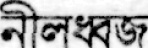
নীলধ্বজ
